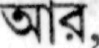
আর,
